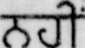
ਨਹੀਂ
